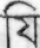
যি
